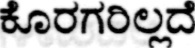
ಕೊರಗರಿಲ್ಲದೆ
